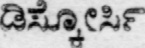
ಡಿಸ್ಕೋರ್ಸಿ
